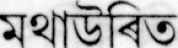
মথাউৰিত
